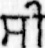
ਸੀ
